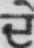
ਦੇ
